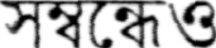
সম্বন্ধেও
